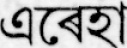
এৰেহা
